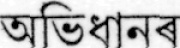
অভিধানৰ
